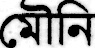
মৌনি
